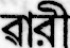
ৱারী
